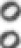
ঃ
